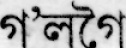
গ'লগৈ
